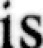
is
